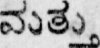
ಮತ್ತು
